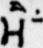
ਮੈਂ
